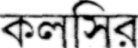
কলসির
